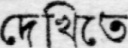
দেখিতে
